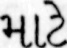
માટે
